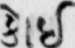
કોઈ
